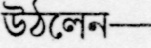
উঠলেন–
